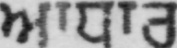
ਆਧਾਰ
